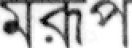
মরূপ
